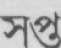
সপ্ত
